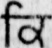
ਕਿ
